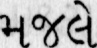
મજલે
